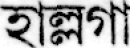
হাল্লগা
